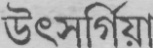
উৎসৰ্গিয়া
